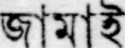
জামাই
